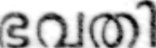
ഭവതി
